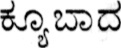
ಕ್ಯೂಬಾದ
